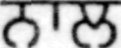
ਨਾਲ
